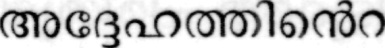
അദ്ദേഹത്തിന്റെ
